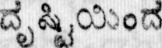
ದೃಷ್ಟಿಯಿಂದ
